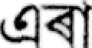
এৰা
